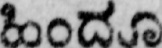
ಹಿಂದೂ
